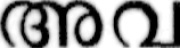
അവ
